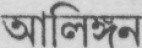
আলিঙ্গন
